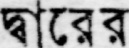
দ্বারের
